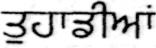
ਤੁਹਾਡੀਆਂ
